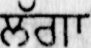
ਲੱਗਾ
